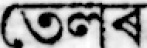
তেলৰ
